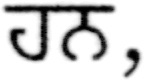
ਹਨ,
